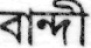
বান্দী
